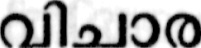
വിചാര
